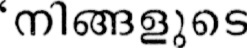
‘നിങ്ങളുടെ
